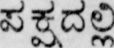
ಪಕ್ಷದಲ್ಲಿ
